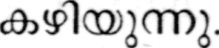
കഴിയുന്നു.
